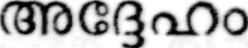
അദ്ദേഹം
